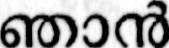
ഞാന്‍
